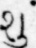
શું
